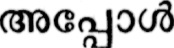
അപ്പോള്‍
